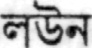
লউন
